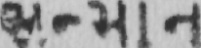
સન્માન
